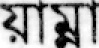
য়াম্না
